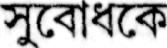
সুবোধকে
